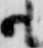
ન
